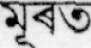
মূৰত
